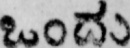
ಒಂದು
